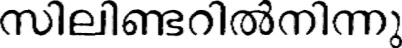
സിലിണ്ടറില്‍നിന്നു
